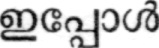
ഇപ്പോള്‍
